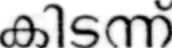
കിടന്ന്
